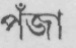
পঁজা
